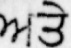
ਅਤੇ
